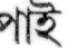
পাই
